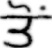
ਤੋਂ
